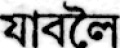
যাবলৈ
